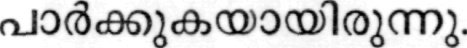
പാര്‍ക്കുകയായിരുന്നു.
